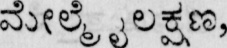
ಮೇಲ್ಮೈಲಕ್ಷಣ,
